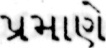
પ્રમાણે
